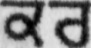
ਕਰ
